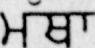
ਮੱਥਾ
